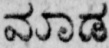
ಮಾಡ
